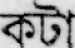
কটা
